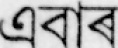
এবাৰ
